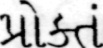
પ્રોક્તં
